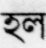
হল
